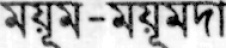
ময়ূম-ময়ূমদা
